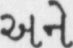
અને
